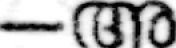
-അ
